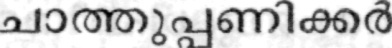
ചാത്തുപ്പണിക്കര്‍
